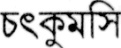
চৎকুমসি
